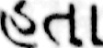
હતા
